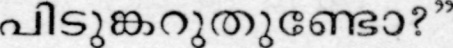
പിടുങ്കറുതുണ്ടോ?”
